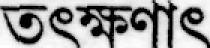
তৎক্ষণাৎ
